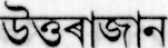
উত্তৰাজান
